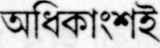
অধিকাংশই
